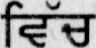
ਵਿੱਚ
